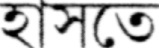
হাসতে
